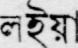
লইয়া
